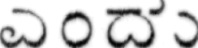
ಎಂದು
